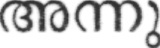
അന്നു
